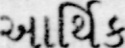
આર્થિક
